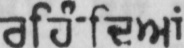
ਰਹਿੰਦਿਆਂ
